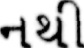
નથી
